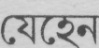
যেহেন
